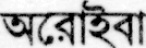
অরোইবা
